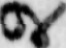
જ
